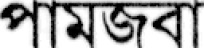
পামজবা
